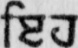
ਇਹ
